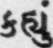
કહ્યું
